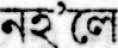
নহ'লে
